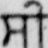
ਸੀ
